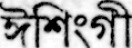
ঈশিংগী
